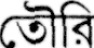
তৌরি
